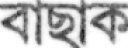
বাছাক
